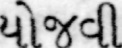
યોજવી
